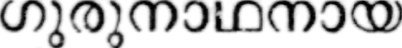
ഗുരുനാഥനായ
